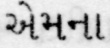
એમના
